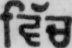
ਵਿੱਚ
